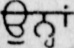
ਉਨ੍ਹਾਂ
